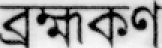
ব্রহ্মকণ
